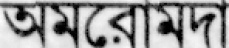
অমরোমদা
